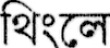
থিংলে
